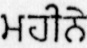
ਮਹੀਨੇ
